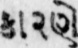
કારણે
